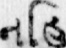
નહિ
